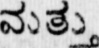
ಮತ್ತು
